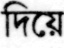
দিয়ে
